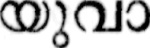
യുവാ
